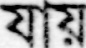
যায়
